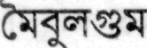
মৈবুলগুম
